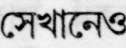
সেখানেও
